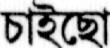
চাইছো
